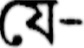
যে-
